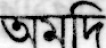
অমদি
